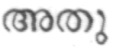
അതു
